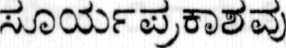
ಸೂರ್ಯಪ್ರಕಾಶವು
